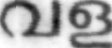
വള
